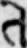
તે
